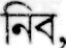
নিব,
